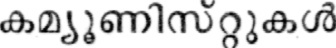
കമ്യൂണിസ്റ്റുകള്‍
